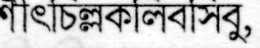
শীৎচিল্লকলিবসিবু,
